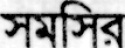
সমসির
